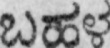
ಬಹಳ
